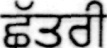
ਛੱਤਰੀ
